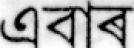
এবাৰ
